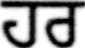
ਹਰ
